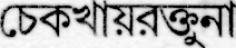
চেকখায়রক্তুনা
